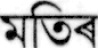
মতিৰ
